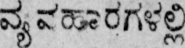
ವ್ಯವಹಾರಗಳಲ್ಲಿ
